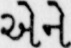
એને
